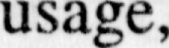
usage,
